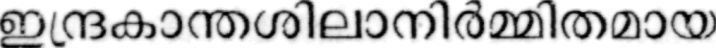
ഇന്ദ്രകാന്തശിലാനിര്‍മ്മിതമായ
